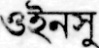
ওইনসু
